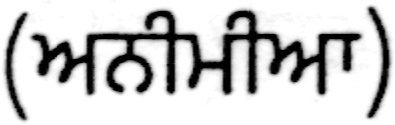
(ਅਨੀਮੀਆ)
